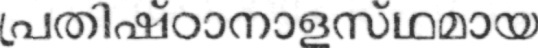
പ്രതിഷ്ഠാനാളസ്ഥമായ
